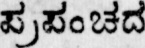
ಪ್ರಪಂಚದ
